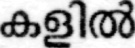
കളില്‍
